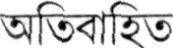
অতিবাহিত
